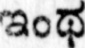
ಇಂಥ
